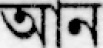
আন
